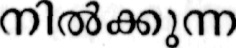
നില്‍ക്കുന്ന
